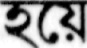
হয়ে
